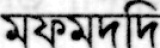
মফমদদি
